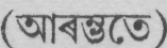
(আৰম্ভতে)
